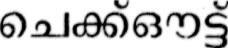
ചെക്ക്ഔട്ട്
